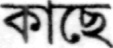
কাছে
